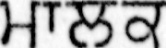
ਮਾਲਕ
